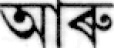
আৰু
